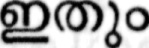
ഇതും
